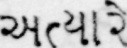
અત્યારે
